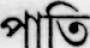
পাতি
